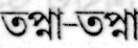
তপ্না-তপ্না
